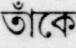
তাঁকে
